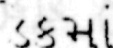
ડેકમાં
